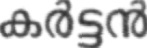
കര്‍ട്ടന്‍
